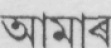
আমাৰ
